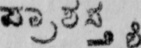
ಪ್ರಾಶಸ್ತ್ಯ
